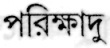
পরিক্ষাদু
